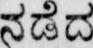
ನಡೆದ
